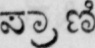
ಪ್ರಾಣಿ
